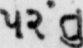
પરંતુ
